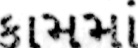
કામમાં
